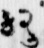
કરું
